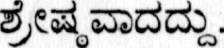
ಶ್ರೇಷ್ಠವಾದದ್ದು.
